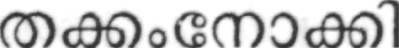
തക്കംനോക്കി
